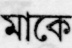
মাকে
